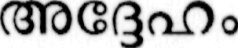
അദ്ദേഹം
